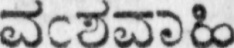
ವಂಶವಾಹಿ
